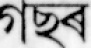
গছৰ
